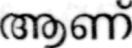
ആണ്
